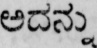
ಅದನ್ನು
